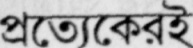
প্রত্যেকেরই
